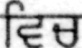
ਵਿਚ
